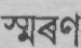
স্মৰণ
